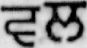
ਵਲ
